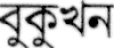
বুকুখন
